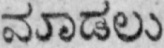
ಮಾಡಲು
